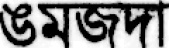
ঙমজদা
